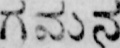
ಗಮನ
